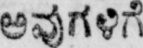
ಅವುಗಳಿಗೆ
